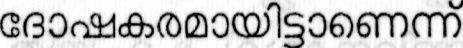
ദോഷകരമായിട്ടാണെന്ന്
